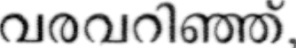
വരവറിഞ്ഞ്,
